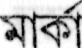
মার্কা
